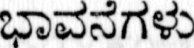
ಭಾವನೆಗಳು
